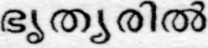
ഭൃത്യരില്‍
